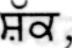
ਸ਼ੱਕ,
